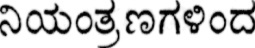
ನಿಯಂತ್ರಣಗಳಿಂದ
